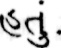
હતું.
